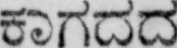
ಕಾಗದದ
